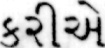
કરીએ
